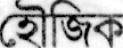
হৌজিক
